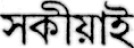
সকীয়াই
